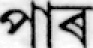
পাৰ
